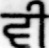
ਵੀ
